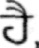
ਹੈ,
